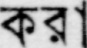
করা
